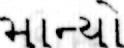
માન્યો
